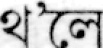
থ'লে
